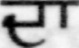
ਦਾ
